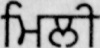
ਮਿਲੀ
